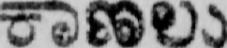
ಕಾಣಲು
